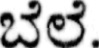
ಬೆಲೆ.
